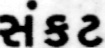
સંકટ
